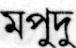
মপুদু
